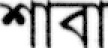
শাবা
